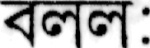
বলল:
